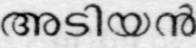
അടിയന്‍
